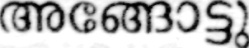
അങ്ങോട്ടു
